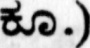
ಕೂ.)
